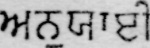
ਅਨੁਯਾਈ
